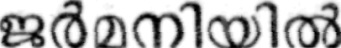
ജര്‍മനിയില്‍
